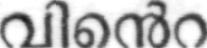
വിന്റെ
